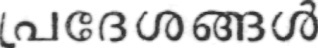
പ്രദേശങ്ങള്‍
